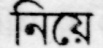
নিয়ে
